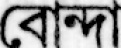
বোন্দা
